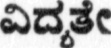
ವಿದ್ಯತೇ
